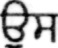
ਉਸ
